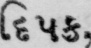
દિપક,
